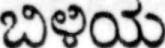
ಬಿಳಿಯ
